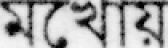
মখোয়
